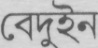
বেদুইন
